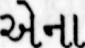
એના
